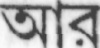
আর
